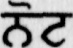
ਨੋਟ
